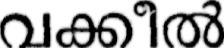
വക്കീല്‍
